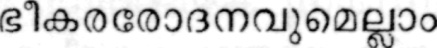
ഭീകരരോദനവുമെല്ലാം
